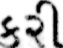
કરી
